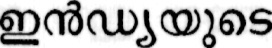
ഇന്‍ഡ്യയുടെ
